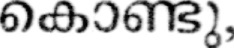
കൊണ്ടു,
